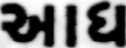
આધ
